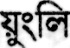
য়ুংলি
